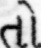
તો
